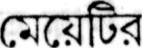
মেয়েটির
